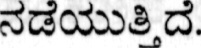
ನಡೆಯುತ್ತಿದೆ.
